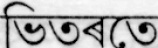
ভিতৰতে
